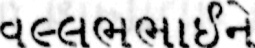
વલ્લભભાઈને
